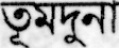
তূমদুনা
